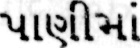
પાણીમાં
